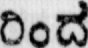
ರಿಂದ
